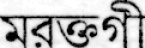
মরক্তগী
